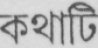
কথাটি
